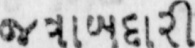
જવાબદારી
